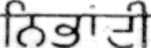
ਨਿਭਾਂਦੀ
